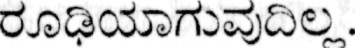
ರೂಢಿಯಾಗುವುದಿಲ್ಲ.
